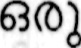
ഒരു
